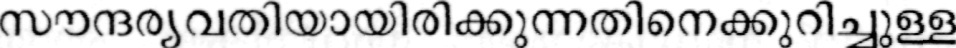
സൗന്ദര്യവതിയായിരിക്കുന്നതിനെക്കുറിച്ചുള്ള
